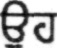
ਉਹ
